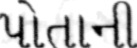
પોતાની
